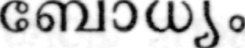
ബോധ്യം
